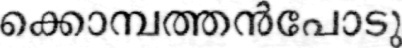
ക്കൊമ്പത്തന്‍പോടു
